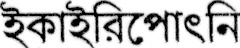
ইকাইরিপোৎনি
